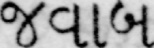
જવાબ
